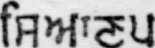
ਸਿਆਣਪ
